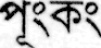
পূংকং
